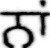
ਨਾ
